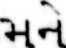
મને
